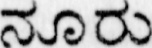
ನೂರು
